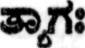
ತ್ಯಾಗಃ
